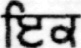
ਇਕ
